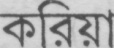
করিয়া
